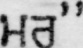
ਮਰ''
